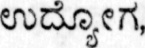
ಉದ್ಯೋಗ,
